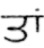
ਤਾਂ
